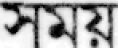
সময়
